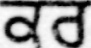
ਕਰ
